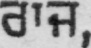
ਰਾਜ,
